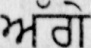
ਅੱਗੇ
